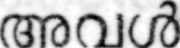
അവള്‍
